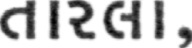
તારલા,
